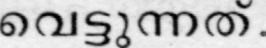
വെട്ടുന്നത്.
